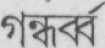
গন্ধৰ্ব্ব
